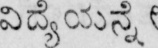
ವಿದ್ಯೆಯನ್ನೇ
